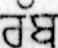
ਰੱਬ
